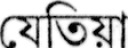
যেতিয়া
